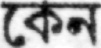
কেন
